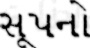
સૂપનો
